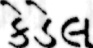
કેડેલ
